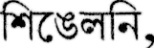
শিঙেলনি,
